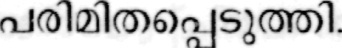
പരിമിതപ്പെടുത്തി.
